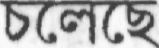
চলেছে
